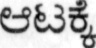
ಆಟಕ್ಕೆ
